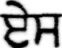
ਏਸ
